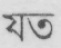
যত
